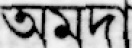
অমদা
